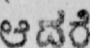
ಆದರೆ
